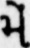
મેં
